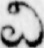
ವಿ
